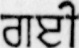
ਗਈ
